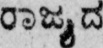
ರಾಜ್ಯದ
